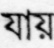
যায়
